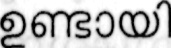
ഉണ്ടായി
